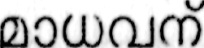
മാധവന്
